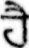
ਹੈ
